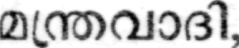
മന്ത്രവാദി,
